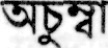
অচুম্বা
